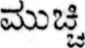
ಮುಚ್ಚಿ
